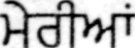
ਮੇਰੀਆਂ
